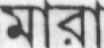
মারা
